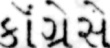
કૉંગ્રેસે
